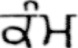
ਕੰਮ
